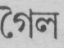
গৈল
